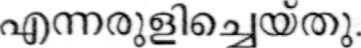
എന്നരുളിച്ചെയ്തു.
